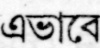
এভাবে
